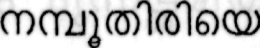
നമ്പൂതിരിയെ
